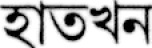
হাতখন
